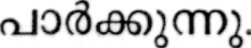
പാര്‍ക്കുന്നു.
